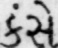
કંસે
